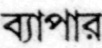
ব্যাপার
